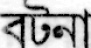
বটনা
